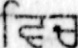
ਵਿਚ
